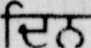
ਦਿਨ
